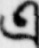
এ
